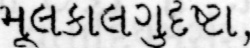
મૂલકાલગુદેષ્ટા,
